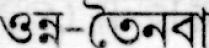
ওন্ন-তৈনবা
